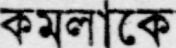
কমলাকে
